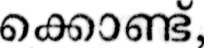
ക്കൊണ്ട്,
